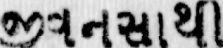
જીવનસાથી
